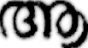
ആ
